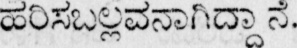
ಹರಿಸಬಲ್ಲವನಾಗಿದ್ದಾನೆ.
